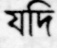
যদি
